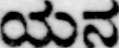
ಯನ
